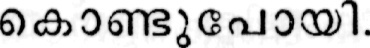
കൊണ്ടുപോയി.
